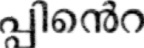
പ്പിന്റെ
